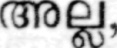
അല്ല,
